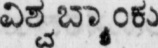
ವಿಶ್ವಬ್ಯಾಂಕು
